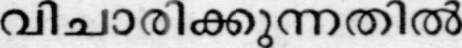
വിചാരിക്കുന്നതില്‍
